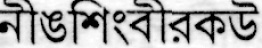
নীঙশিংবীরকউ
